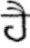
ਹੈ
